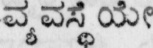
ವ್ಯವಸ್ಥೆಯೇ
